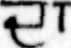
ਦਾ
